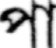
পা
